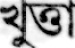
খুত্তা
